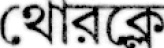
থোরক্লে
